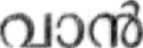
വാന്‍
